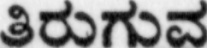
ತಿರುಗುವ
